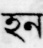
হন
